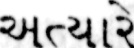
અત્યારે
